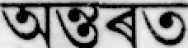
অন্তৰত
